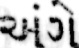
અંગે
